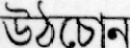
উঠচোন
